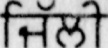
ਜਿੱਲੀ
